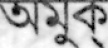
অমুক্
